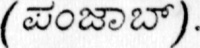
(ಪಂಜಾಬ್).
